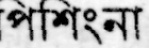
পিশিংনা
